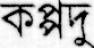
কপ্পদু
